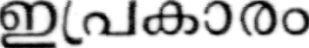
ഇപ്രകാരം
